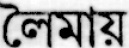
লৈমায়
